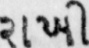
રાખી
